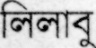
লিলাবু
